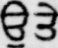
ਉਤੇ
